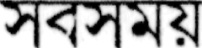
সবসময়
